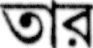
তার
